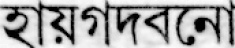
হায়গদবনো
